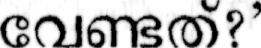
വേണ്ടത്?'
